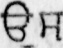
ਉਸ
